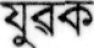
যুৱক
